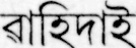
ৱাহিদাই
